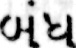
બંધ
